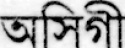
অসিগী
